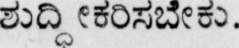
ಶುದ್ಧೀಕರಿಸಬೇಕು.
